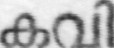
കവി
